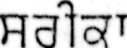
ਸਰੀਕਾ
